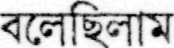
বলেছিলাম
